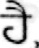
ਹੈ,
